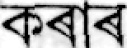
কৰাৰ
